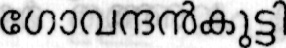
ഗോവന്ദന്‍കുട്ടി
